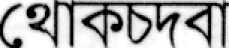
থোকচদবা
